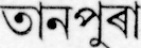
তানপুৰা
